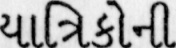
યાત્રિકોની
